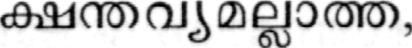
ക്ഷന്തവ്യമല്ലാത്ത,
